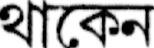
থাকেন
